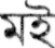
মই
